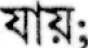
যায়;
